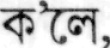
ক'লে,
